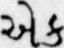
એક
